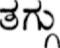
ತಗ್ಗು
